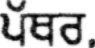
ਪੱਥਰ,
